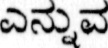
ಎನ್ನುವ
